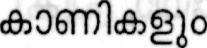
കാണികളും
